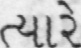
ત્યારે
